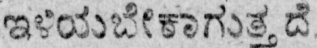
ಇಳೆಯಬೇಕಾಗುತ್ತದೆ.
